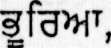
ਭੂਰਿਆ,
